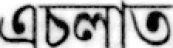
এচলাত
